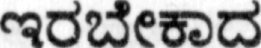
ಇರಬೇಕಾದ
